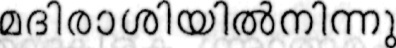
മദിരാശിയില്‍നിന്നു
